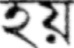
হয়
